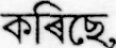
কৰিছে,
